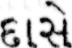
દાસે
